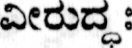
ವೀರುದ್ಧಃ
